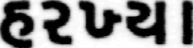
હરખ્યા
